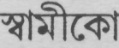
স্বামীকো
